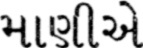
માણીએ
